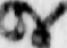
જ
